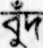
বুঁদ
